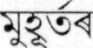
মুহূর্তৰ
